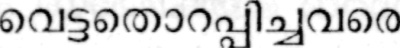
വെട്ടതൊറപ്പിച്ചവരെ
